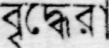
বৃদ্ধেরা
